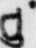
તું
